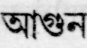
আগুন
